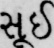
સૂઈ
